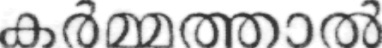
കര്‍മ്മത്താല്‍
